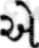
એ
